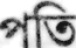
পতি
